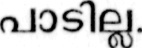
പാടില്ല.
